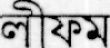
লীফম
